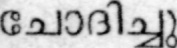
ചോദിച്ചു
